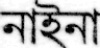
নাইনা
